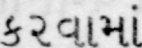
કરવામાં
